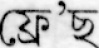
ফ্রে'ছ
